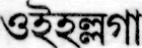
ওইহল্লগা
